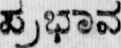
ಪ್ರಭಾವ
